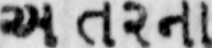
અંતરના
